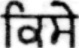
ਕਿਸੇ
